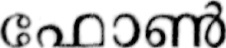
ഫോണ്‍
